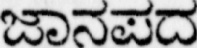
ಜಾನಪದ
